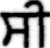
ਸੀ
